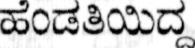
ಹೆಂಡತಿಯಿದ್ದ
